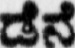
ಡೆನೆ
